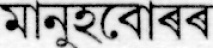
মানুহবোৰৰ
